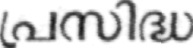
പ്രസിദ്ധ
